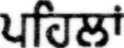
ਪਹਿਲਾਂ
